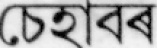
চেহাবৰ
